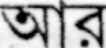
আর
